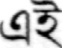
এই
